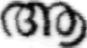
ആ
